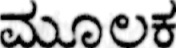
ಮೂಲಕ
